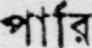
পারি
